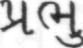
પ્રભુ
